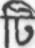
টি
